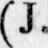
(J.
